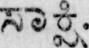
ಸಾಕ್ಷಿ.
